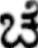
ಚೆ
